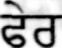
ਫੇਰ
